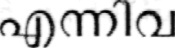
എന്നിവ
